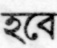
হবে
